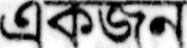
একজন
